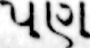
પણ
